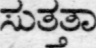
ಸುತ್ತತ್ತಾ
